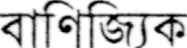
বাণিজ্যিক
